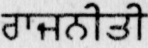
ਰਾਜਨੀਤੀ
